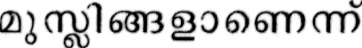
മുസ്ളിങ്ങളാണെന്ന്
